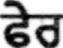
ਫੇਰ
